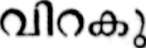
വിറകു
